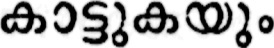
കാട്ടുകയും
